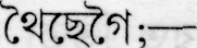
থৈছেগৈ;-
